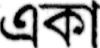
একা
